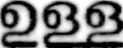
ഉള്ള
